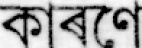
কাৰণে
